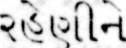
રહેણીને
